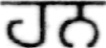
ਹਨ
